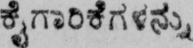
ಕೈಗಾರಿಕೆಗಳನ್ನು
